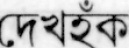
দেখহঁক
